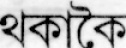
থকাকৈ
